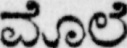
ಮೊಲೆ
